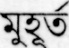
মুহূর্ত
